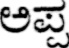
ಅಪ್ಪ
